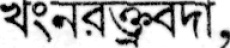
খংনরক্ত্রবদা,
